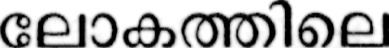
ലോകത്തിലെ
